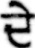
ਦੇ
